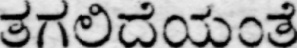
ತಗಲಿದೆಯಂತೆ
